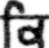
ਕਿ
